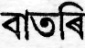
বাতৰি
